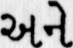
અને
